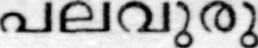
പലവുരു
